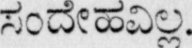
ಸಂದೇಹವಿಲ್ಲ.
